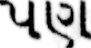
પણ
